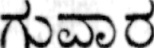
ಗುವಾರ
